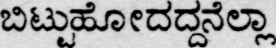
ಬಿಟ್ಟುಹೋದದ್ದನೆಲ್ಲಾ
